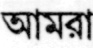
আমরা
